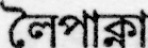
লৈপাক্না
